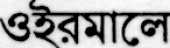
ওইরমালে
